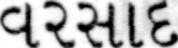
વરસાદ
